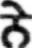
ਨੇ
